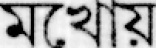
মখোয়
